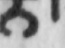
ਨਾ
